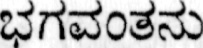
ಭಗವಂತನು
